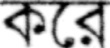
করে
